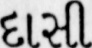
દાસી
